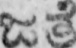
ಜತೆ
